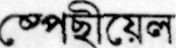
স্পেছীয়েল
